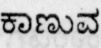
ಕಾಣುವ
